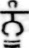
ਨੂੰ
